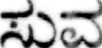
ಸುವ
